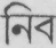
নিব
